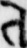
તે
